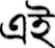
এই
